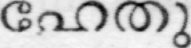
ഹേതു
